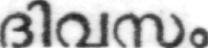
ദിവസം
